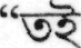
"তই
